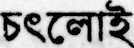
চৎলোই
